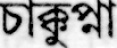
চাক্কুপ্না
